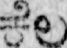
ಕೆಲ
